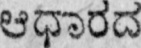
ಆಧಾರದ
